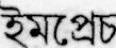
ইমপ্রেচ
